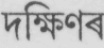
দক্ষিণৰ
